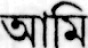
আমি
